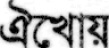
ঐখোয়
